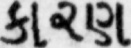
કારણ
